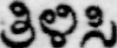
ತಿಳಿಸಿ
